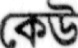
কেউ
